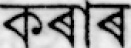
কৰাৰ
